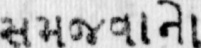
સમજવાનો
